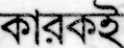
কারকই
